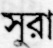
সুরা
